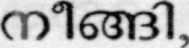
നീങ്ങി,
